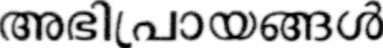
അഭിപ്രായങ്ങള്‍
